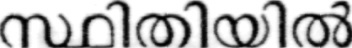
സ്ഥിതിയില്‍
